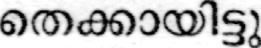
തെക്കായിട്ടു
